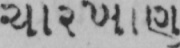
ચારખાણ
